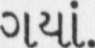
ગયાં.
